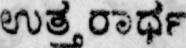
ಉತ್ತರಾರ್ಧ
